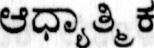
ಆಧ್ಯಾತ್ಮಿಕ
